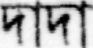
দাদা
